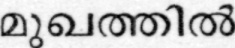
മുഖത്തില്‍
